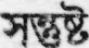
সন্তুষ্ট
